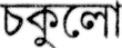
চকুলো
